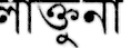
লাক্তুনা
